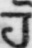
ਹੋ
